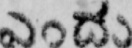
ಎಂದು
